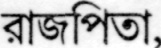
রাজপিতা,
